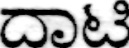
ದಾಟಿ
